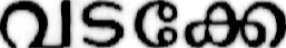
വടക്കേ
